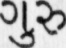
ગુરુ
